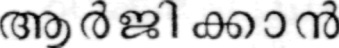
ആര്‍ജിക്കാന്‍
